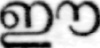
ഈ
